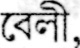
বেলী,
